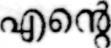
എന്റെ
